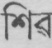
শিৱ
